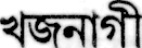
খজনগী
